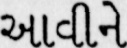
આવીને
